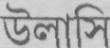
উলাসি
